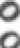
ঃ
